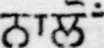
ਨਾਲੋਂ
